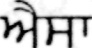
ਐਸਾ
